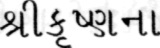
શ્રીકૃષ્ણ
